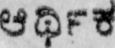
ಆರ್ಥಿಕ
